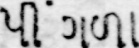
પીંગળા
